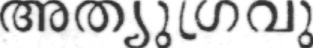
അത്യുഗ്രവു
